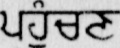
ਪਹੁੰਚਣ
